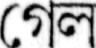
গেল
